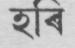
হৰি
